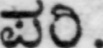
ಪರಿ.
